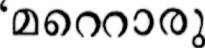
‘മറെറാരു
